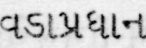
વડાપ્રધાન
